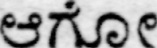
ಆಗೋ
